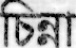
চিন্না
